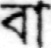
বা
